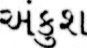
અંકુશ
